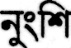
নুংশি
